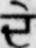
ਦੇ
